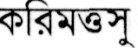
করিমত্তসু
